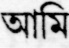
আমি
